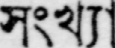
সংখ্যা
